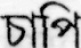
চাপি
